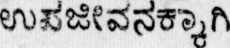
ಉಪಜೀವನಕ್ಕಾಗಿ
